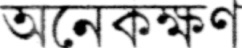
অনেকক্ষণ
